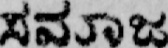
ಸಮಾಜ
